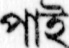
পাই
